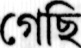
গেছি
